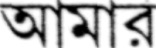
আমার
